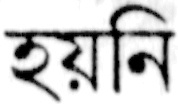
হয়নি
